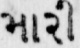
મારી
